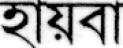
হায়বা
